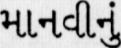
માનવીનું
